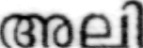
അലി
